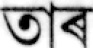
তাৰ
